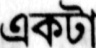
একটা
